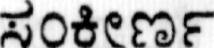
ಸಂಕೀರ್ಣ
